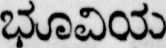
ಭೂವಿಯ
